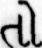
તો
